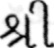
શ્રી
